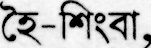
হৈ-শিংবা,
